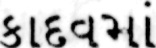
કાદવમાં
